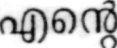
എന്റെ
